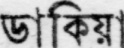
ডাকিয়া
